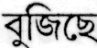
বুজিছে
